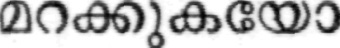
മറക്കുകയോ
